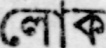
লোক
